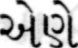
એણે
